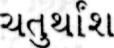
ચતુર્થાંશ
